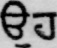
ਉਹ
